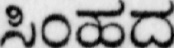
ಸಿಂಹದ
